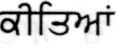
ਕੀਤਿਆਂ
